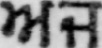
ਅਜ
